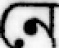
নে
